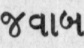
જવાબ
